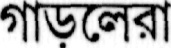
গাড়লেরা
